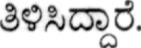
ತಿಳಿಸಿದ್ದಾರೆ.
